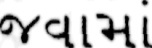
જવામાં
